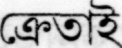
ক্রেতাই
